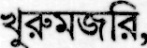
খুরুমজরি,
